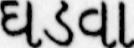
ઘડવા
